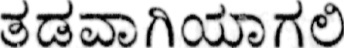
ತಡವಾಗಿಯಾಗಲಿ
